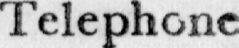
Telephone
